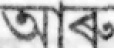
আৰু
